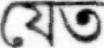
যেত
